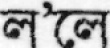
ল'লে
